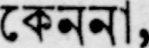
কেননা,
